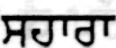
ਸਹਾਰਾ
